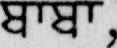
ਬਾਬਾ,
